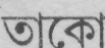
তাকো
